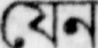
যেন
